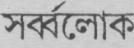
সৰ্ব্বলোক
